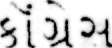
કોંગ્રેસ
